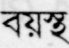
বয়স্থ
